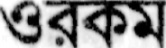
ওরকম
